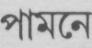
পামনে
